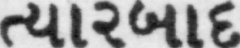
ત્યારબાદ
